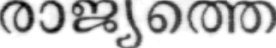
രാജ്യത്തെ
